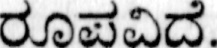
ರೂಪವಿದೆ.
